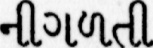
નીગળતી
